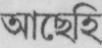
আছেহি
